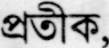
প্রতীক,
